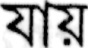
যায়
